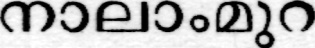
നാലാംമുറ
